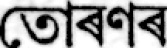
তোৰণৰ
